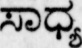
ಸಾಧ್ಯ
